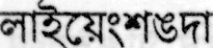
লাইয়েংশঙদা
